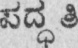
ಪದ್ಧತಿ
